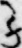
કે
